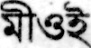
মীওই
